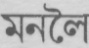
মনলৈ
